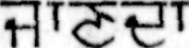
ਜਾਣਦਾ
